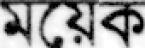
ময়েক
